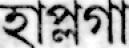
হাপ্লগা
